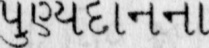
પુણ્યદાનના
